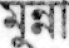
মুননা
